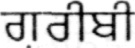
ਗ਼ਰੀਬੀ
